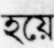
হয়ে
